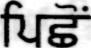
ਪਿਛੋਂ
